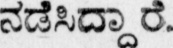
ನಡೆಸಿದ್ದಾರೆ.
